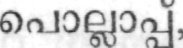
പൊല്ലാപ്പ്,
